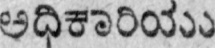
ಅಧಿಕಾರಿಯು
